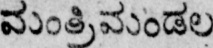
ಮಂತ್ರಿಮಂಡಲ
